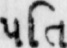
પતિ
